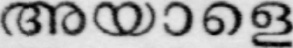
അയാളെ
